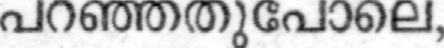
പറഞ്ഞതുപോലെ,
